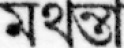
মথন্তা
